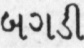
બગડી
